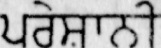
ਪਰੇਸ਼ਾਨੀ
